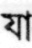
যা
